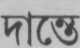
দান্তে
